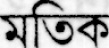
মতিক
